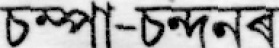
চম্পা-চন্দনৰ
